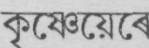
কৃষ্ণেয়েৰে
